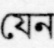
যেন
